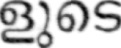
ളുടെ
